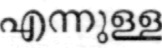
എന്നുള്ള
